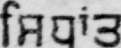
ਸਿਧਾਂਤ
